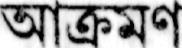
আক্রমণ
